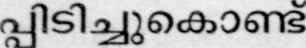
പ്പിടിച്ചുകൊണ്ട്
